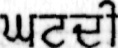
ਘਟਦੀ
